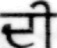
ਦੀ
